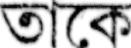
তাকে
